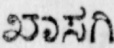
ಖಾಸಗಿ
